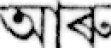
আৰু
